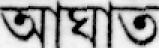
আঘাত
